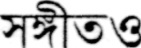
সঙ্গীতও
